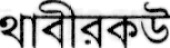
থাবীরকউ
